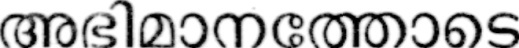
അഭിമാനത്തോടെ
